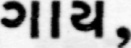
ગાય,
